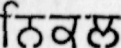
ਨਿਕਲ
